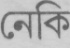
নেকি
